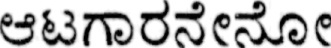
ಆಟಗಾರನೇನೋ
